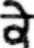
ਕੇ
